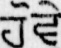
ਹੋਵੇ
